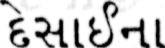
દેસાઈના
